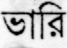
ভারি
